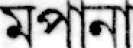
মপানা
